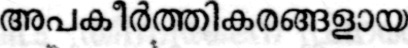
അപകീര്‍ത്തികരങ്ങളായ
